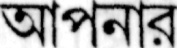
আপনার
